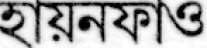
হায়নফাও
